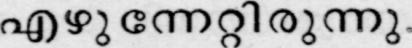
എഴുന്നേറ്റിരുന്നു.
